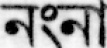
নংনা
